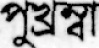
পুখ্রম্বা
